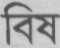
বিষ
